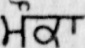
ਮੌਕਾ
